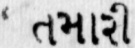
'તમારી
